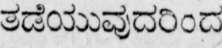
ತಡೆಯುವುದರಿಂದ
